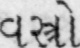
વસ્ત્રો
